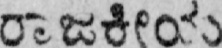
ರಾಜಕೀಯ
